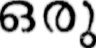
ഒരു
